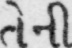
તેની
